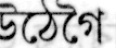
উঠেগৈ
